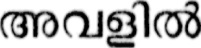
അവളില്‍
